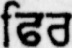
ਫਿਰ
